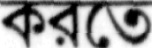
করতে
